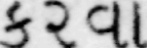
કરવા
